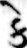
કે
